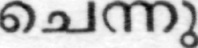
ചെന്നു
